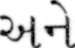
અને
